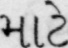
માટે
